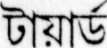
টায়ার্ড
